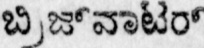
ಬ್ರಿಜ್ವಾಟರ್
